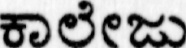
ಕಾಲೇಜು
